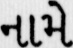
નામે
